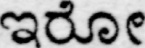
ಇರೋ
